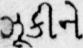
ઝૂકીને
